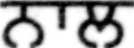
ਨਾਲ
